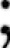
ং
